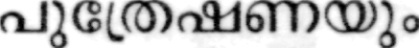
പുത്രേഷണയും
